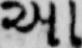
આ
